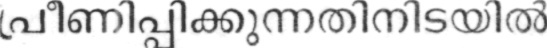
പ്രീണിപ്പിക്കുന്നതിനിടയില്‍
